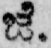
ಜೆ.
